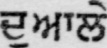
ਦੁਆਲੇ
